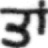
ਤਾਂ
